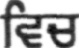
ਵਿਚ
